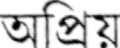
অপ্রিয়
